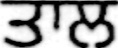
ਤਾਲ
